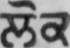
ਲੋਕ
